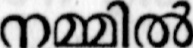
നമ്മില്‍
